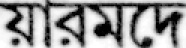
য়ারমদে
